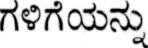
ಗಳಿಗೆಯನ್ನು
